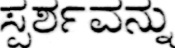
ಸ್ಪರ್ಶವನ್ನು
